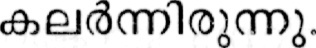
കലര്‍ന്നിരുന്നു.
